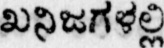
ಖನಿಜಗಳಲ್ಲಿ
